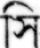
সি
